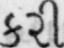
કરી
